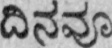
ದಿನವೂ
